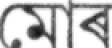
মোৰ
